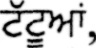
ਟੱਟੂਆਂ,
